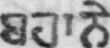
ਬਹਾਨੇ
